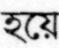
হয়ে
